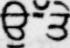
ਉੱਤੇ
